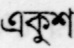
একুশ
